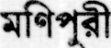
মণিপুরী
